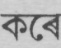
কৰে
